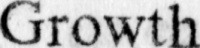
Growth
